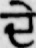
ਦੇ
